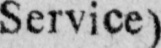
Service)
